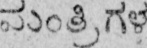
ಮಂತ್ರಿಗಳ
